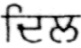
ਦਿਲ
